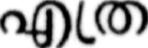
എത്ര
